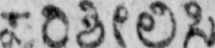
ಪರಿಶೀಲಿಸಿ
